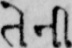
તેની
